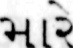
મારે
